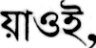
য়াওই,
